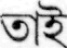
তাই
